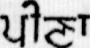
ਪੀਣਾ
